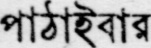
পাঠাইবার
